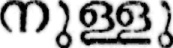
നുള്ളു
